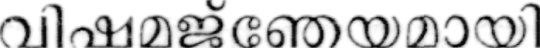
വിഷമജ്ഞേയമായി
